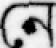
নে
